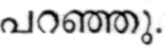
പറഞ്ഞു.
